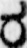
ರ
